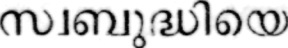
സ്വബുദ്ധിയെ
